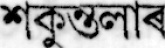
শকুন্তলাৰ
